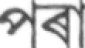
পৰা
